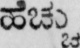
ಹೆಚ್ಚು
